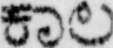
ಕಾಲ
